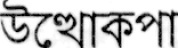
উত্থোকপা
